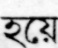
হয়ে
